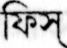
ফিস্
